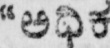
“ಅಧಿಕ
